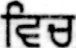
ਵਿਚ
